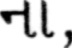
ના,
